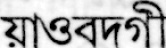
য়াওবদগী
